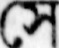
সে
